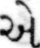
એ
